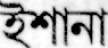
ইশানা
